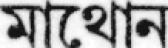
মাথোন
